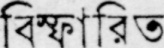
বিস্ফারিত
